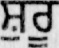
ਸ਼ੁਰੂ
